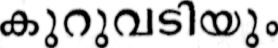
കുറുവടിയും
